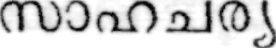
സാഹചര്യ
